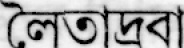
লৈতাদ্রবা
